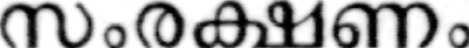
സംരക്ഷണം
